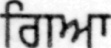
ਗਿਆ
